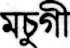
মচুগী
